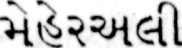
મેહેરઅલી
